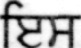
ਇਸ
